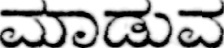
ಮಾಡುವ
